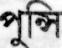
পুন্সি
